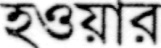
হওয়ার
